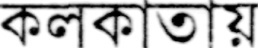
কলকাতায়
